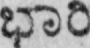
ಭಾರಿ
